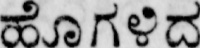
ಹೊಗಳಿದ
